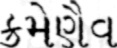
ક્રમેણૈન
